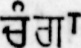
ਚੰਗਾ
